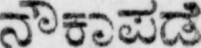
ನೌಕಾಪಡೆ
